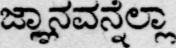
ಜ್ಞಾನವನ್ನೆಲ್ಲಾ
